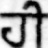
ਹੀ
